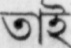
তাই
